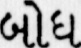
બોધ
